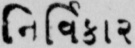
નિર્વિકાર
